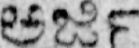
ಅರ್ಜಿ
